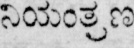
ನಿಯಂತ್ರಣ
